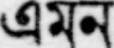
এমন
